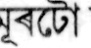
মূৰটো
